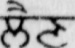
ਲੈਣ
